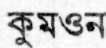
কুমওন
